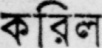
করিল
